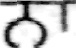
ਨਾ
